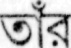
তাঁর
